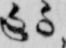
હઠ
